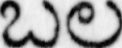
ಬಲ
